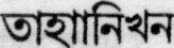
তাহানিখন
